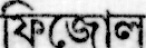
ফিজোল
